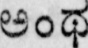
ಅಂಥ
